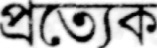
প্রত্যেক
